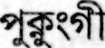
পুক্নুংগী
